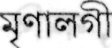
মৃণালগী
